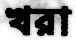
খরা
